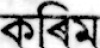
কৰিম
